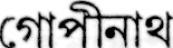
গোপীনাথ
